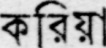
করিয়া
